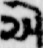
એ
